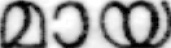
മായ
